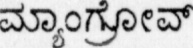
ಮ್ಯಾಂಗ್ರೋವ್
